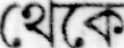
থেকে
